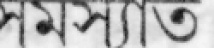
সমস্যাত
